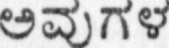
ಅವುಗಳ
